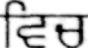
ਵਿਚ
